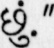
છું."
